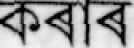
কৰাৰ
